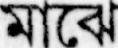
মাঝে
